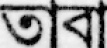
তাবা
